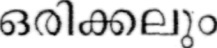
ഒരിക്കലും
